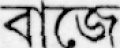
বাজে
